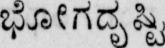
ಭೋಗದೃಷ್ಟಿ
